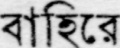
বাহিরে
